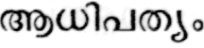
ആധിപത്യം
